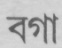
বগা
